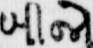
બીજો
